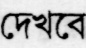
দেখবে
